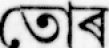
তোৰ
